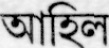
আহিল
